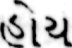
હોય
